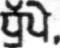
ਧੁੱਪੇ,
